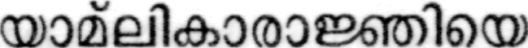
യാമ്ലികാരാജ്ഞിയെ
